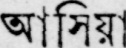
আসিয়া
